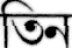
তিন
